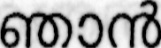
ഞാന്‍
